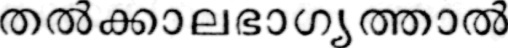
തല്‍ക്കാലഭാഗ്യത്താല്‍
